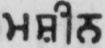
ਮਸ਼ੀਨ
